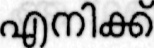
എനിക്ക്
